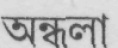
অন্ধলা
